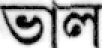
ভাল
